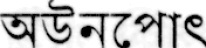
অউনপোৎ
